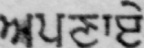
ਅਪਣਾਏ
